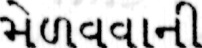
મેળવવાની
